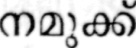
നമുക്ക്
